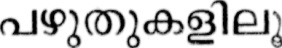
പഴുതുകളിലൂ
